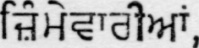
ਜ਼ਿੰਮੇਵਾਰੀਆਂ,
